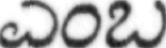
ಎಂಬ
